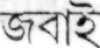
জবাই
